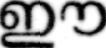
ഈ
